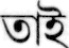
তাই
